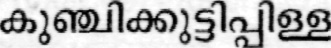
കുഞ്ചിക്കുട്ടിപ്പിള്ള
